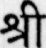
श्री
